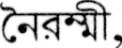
নৈরম্মী,
